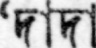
‘দাদা
